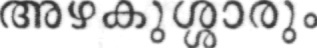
അഴകുശ്ശാരും
